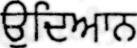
ਉਦਿਆਨ
